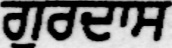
ਗੁਰਦਾਸ
